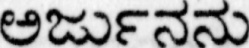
ಅರ್ಜುನನು
